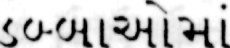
ડબ્બાઓમાં
